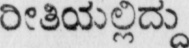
ರೀತಿಯಲ್ಲಿದ್ದು
